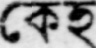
কেহ
